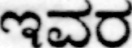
ಇವರ
